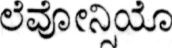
ಲೆವೋನ್ಸಿಯೊ
